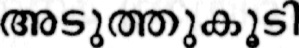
അടുത്തുകൂടി
